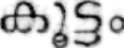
കൂട്ടം
